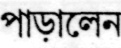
পাড়ালেন
